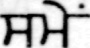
ਸਮੇਂ
